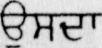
ਉਸਦਾ
